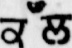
ਕੱਲ
